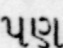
પણ
